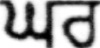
ਘਰ
